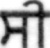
ਸੀ
